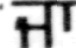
ਜਾ
